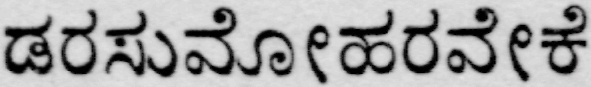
ಡರಸುಮೋಹರವೇಕ್
